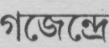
গজেন্দ্ৰে
